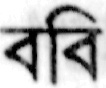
ববি
